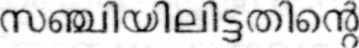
സഞ്ചിയിലിട്ടതിന്റെ
